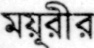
ময়ূরীর
